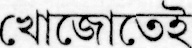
খোজোতেই
